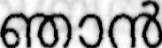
ഞാന്‍
